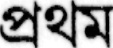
প্রথম
